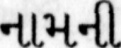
નામની
